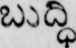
ಬುದ್ಧಿ
